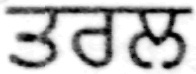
ਤਰਲ
